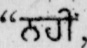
''ਨਹੀਂ,
